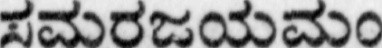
ಸಮರಜಯಮಂ
